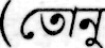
(তোনু
